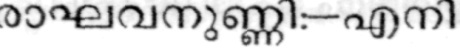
രാഘവനുണ്ണി:-എനി
